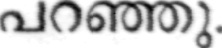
പറഞ്ഞു.
